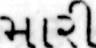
મારી
